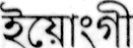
ইয়োংগী
